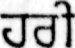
ਹਰੀ
